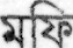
মফি
